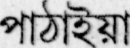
পাঠাইয়া
